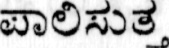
ಪಾಲಿಸುತ್ತ
